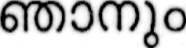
ഞാനും
